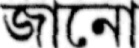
জানো
